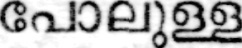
പോലുള്ള
